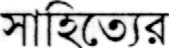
সাহিত্যের
